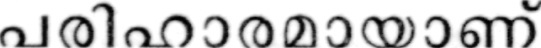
പരിഹാരമായാണ്
